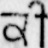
ਕੀ
